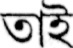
তাই
